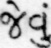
જેવું
